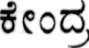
ಕೇಂದ್ರ
